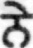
ਨੇ
